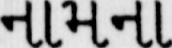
નામના
